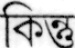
কিন্ত
